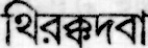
থিরক্কদবা
